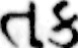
તક
